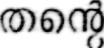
തന്റെ
